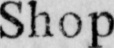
Shop
